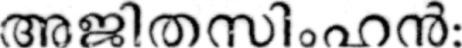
അജിതസിംഹന്‍:
